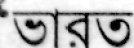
‘ভারত
